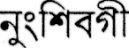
নুংশিবগী
